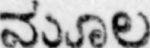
ಮೂಲ
